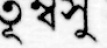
তূম্বসু
